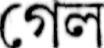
গেল
